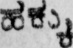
ಹಕ್ಕು
